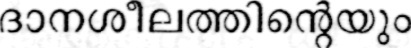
ദാനശീലത്തിന്റെയും
